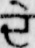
ਦੇ
